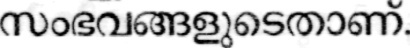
സംഭവങ്ങളുടെതാണ്.
